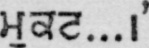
ਮੁਕਟ............।'
